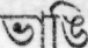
ভাঙি
